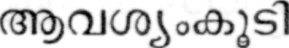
ആവശ്യംകൂടി
